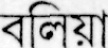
বলিয়া
